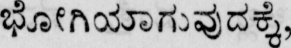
ಭೋಗಿಯಾಗುವುದಕ್ಕೆ,
